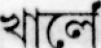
খালে
